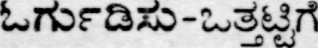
ಒರ್ಗುಡಿಸು-ಒತ್ತಟ್ಟಿಗೆ
